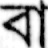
বা
